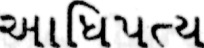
આધિપત્ય
